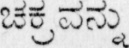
ಚಕ್ರವನ್ನು
